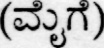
(ಮೈಗೆ)
